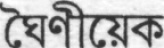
ঘৈণীয়েক
